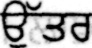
ਉੱਤਰ
